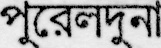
পুরেলদুনা
